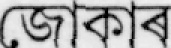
জোকাৰ
